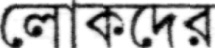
লোকদের
